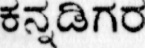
ಕನ್ನಡಿಗರ
